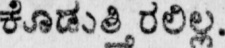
ಕೊಡುತ್ತಿರಲಿಲ್ಲ.
